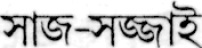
সাজ-সজ্জাই
